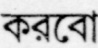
করবো
